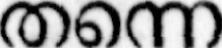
തന്നെ
